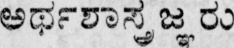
ಅರ್ಥಶಾಸ್ತ್ರಜ್ಞರು
